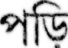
পড়ি
